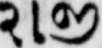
રાજી
